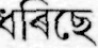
ধৰিছে
